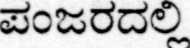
ಪಂಜರದಲ್ಲಿ
